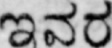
ಇವರ
